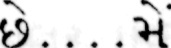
છે....મેં
